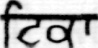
ਟਿਕਾ
